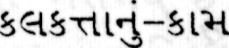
કલકત્તાનું-કામ
